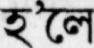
হ'লে
